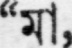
‘‘মা,
